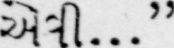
એવી...."
